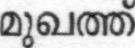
മുഖത്ത്
